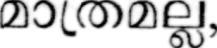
മാത്രമല്ല,
